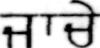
ਜਾਚੇ
